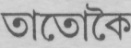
তাতোকৈ
